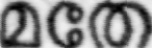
മതേ
